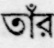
তাঁর
